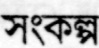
সংকল্প
